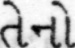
તેનો
